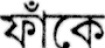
ফাঁকে
